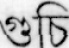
গুচি
